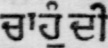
ਚਾਹੁੰਦੀ
